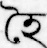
হৈ
